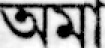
অমা
